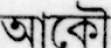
আকৌ
